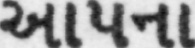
આપના
